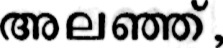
അലഞ്ഞ്,
